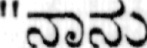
“ನಾನು
